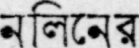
নলিনের
